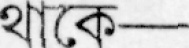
থাকে-
